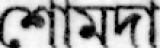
শোমদা
